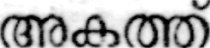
അകത്ത്
